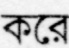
করে
